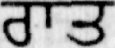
ਰਾਤ
